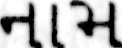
નામ
